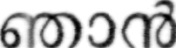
ഞാന്‍
